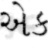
એક
